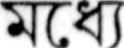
মধ্যে
